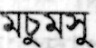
মচুমসু
